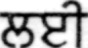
ਲਈ
